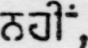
ਨਹੀਂ,
